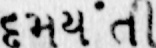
દમયંતી
